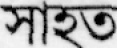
সাহত
